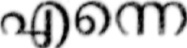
എന്നെ
